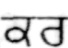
ਕਰ
